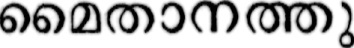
മൈതാനത്തു
